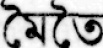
মৈতৈ
